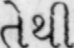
તેથી
